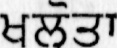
ਖਲੋਤਾ
